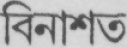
বিনাশত
